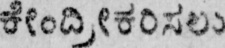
ಕೇಂದ್ರೀಕರಿಸಲು
